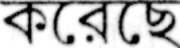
করেছে
